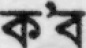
ক'ব
